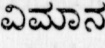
ವಿಮಾನ
